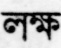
লক্ষ
